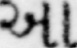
આ
